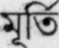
মূর্তি
